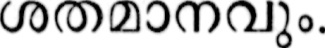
ശതമാനവും.
